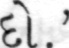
દો.'
